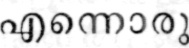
എന്നൊരു
